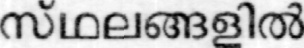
സ്ഥലങ്ങളില്‍
